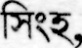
সিংহ,
